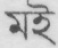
মই
